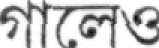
গালেও
